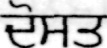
ਦੋਸਤ
